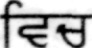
ਵਿਚ
